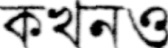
কখনও
